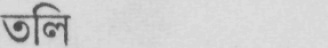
তলি
